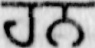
ਹਨ
